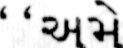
"અમે
